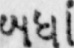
બધાં
